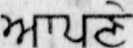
ਆਪਣੇ
